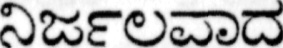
ನಿರ್ಜಲವಾದ
